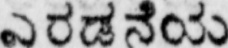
ಎರಡನೆಯ
